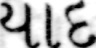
યાદ
